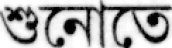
শুনোতে
